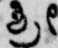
ಶ್ರೀ
